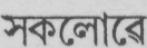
সকলোৱে
